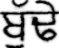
ਬੁੱਢੇ
